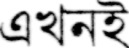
এখনই
